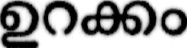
ഉറക്കം
